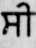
ਸੀ
